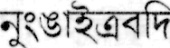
নুংঙাইত্রবদি
